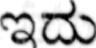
ಇದು
